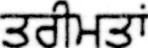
ਤਰੀਮਤਾਂ
